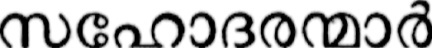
സഹോദരന്മാര്‍
